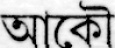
আকৌ
